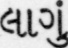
લાગું
